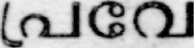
പ്രവേ
